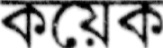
কয়েক
